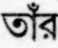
তাঁর
